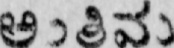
ಅಂತಿಮ
